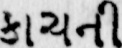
કાચની
